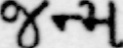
જન્મ
